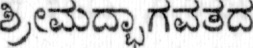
ಶ್ರೀಮದ್ಭಾಗವತದ
